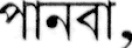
পানবা,
